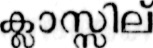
ക്ലാസ്സില്
